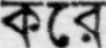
করে
